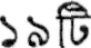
১৯টি
